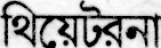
থিয়েটরনা
